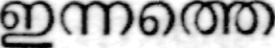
ഇന്നത്തെ
